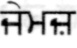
ਜੇਮਜ਼
